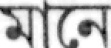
মানে
